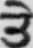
ਤੇ
